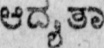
ಆದ್ಯತಾ
